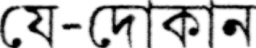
যে-দোকান
